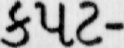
કપટ-
